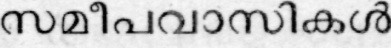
സമീപവാസികള്‍
